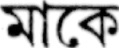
মাকে
